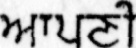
ਆਪਣੀ
